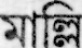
মাল্লি
